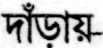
দাঁড়ায়
